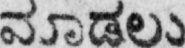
ಮಾಡಲು
